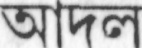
আদল
